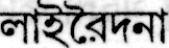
লাইরৈদনা
